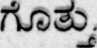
ಗೊತ್ತು.
